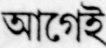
আগেই
